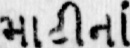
માટીનાં
